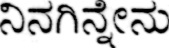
ನಿನಗಿನ್ನೇನು
